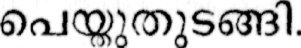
പെയ്തുതുടങ്ങി.
